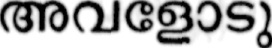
അവളോടു
